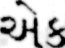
એક
